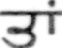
ਤਾਂ
